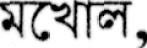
মখোল,
